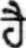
ਹੈ
